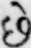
છે
